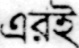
এরই
